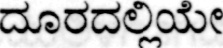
ದೂರದಲ್ಲಿಯೇ
